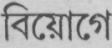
বিয়োগে
